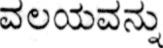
ವಲಯವನ್ನು
